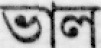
ভাল
